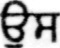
ਉਸ
